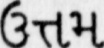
ઉત્તમ
